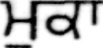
ਮੁਕਾ
